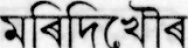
মৰিদিখৌৰ
